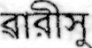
ৱারীসু
